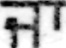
ਜਾ
